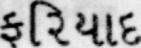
ફરિયાદ
